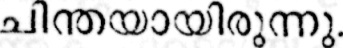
ചിന്തയായിരുന്നു.
